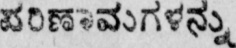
ಪರಿಣಾಮಗಳನ್ನು
